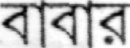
বাবার
